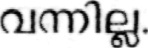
വന്നില്ല.
